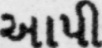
આપી
